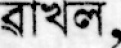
ৱাখল,
